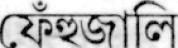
ফেঁহুজালি
